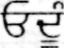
ਓਦੂੰ
